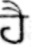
ਹੈ
